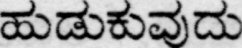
ಹುಡುಕುವುದು
